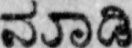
ಮಾಡಿ
